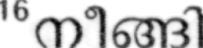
16നീങ്ങി
